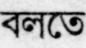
বলতে
